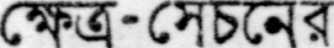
ক্ষেত্র-সেচনের
